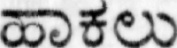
ಹಾಕಲು
